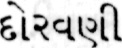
દોરવણી
